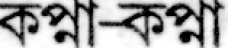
কপ্না-কপ্না
